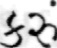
કરું
